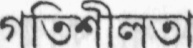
গতিশীলতা
